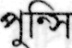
পুন্সি
